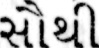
સૌથી
